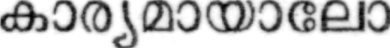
കാര്യമായാലോ
